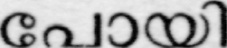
പോയി
